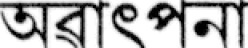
অৱাৎপনা
